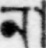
না
